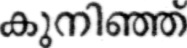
കുനിഞ്ഞ്
